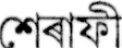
শেৰাফী
